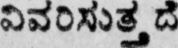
ವಿವರಿಸುತ್ತದೆ
